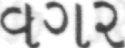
વગર
